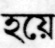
হয়ে
